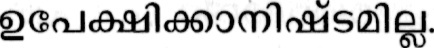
ഉപേക്ഷിക്കാനിഷ്ടമില്ല.
